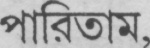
পারিতাম,
